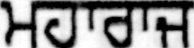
ਮਹਾਰਾਜ
